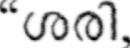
"ശരി,
